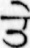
ਤੇ
